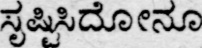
ಸೃಷ್ಟಿಸಿದೋನೂ
